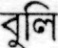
বুলি
